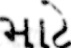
માટે
